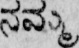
ನಮ್ಮ
